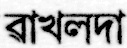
ৱাখলদা
